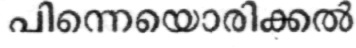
പിന്നെയൊരിക്കല്‍
